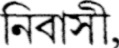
নিবাসী,
